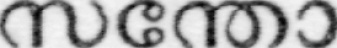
സന്തോ
